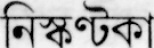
নিস্কণ্টকা
